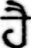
ਹੈ
